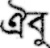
ঐবু
